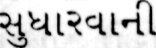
સુધારવાની
